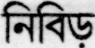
নিবিড়
